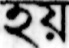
হয়
